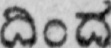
ದಿಂದ
